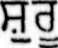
ਸ਼ੁਰੂ
